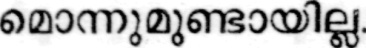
മൊന്നുമുണ്ടായില്ല.
